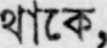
থাকে,
